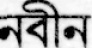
নবীন
